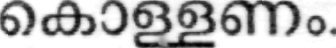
കൊള്ളണം.
